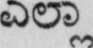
ಎಲ್ಲಾ
